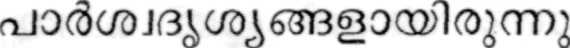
പാര്‍ശ്വദൃശ്യങ്ങളായിരുന്നു
